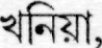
খনিয়া,
